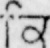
ਕਿ
